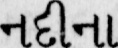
નદીના
